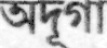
অদূগা
